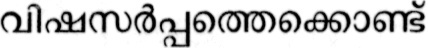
വിഷസര്‍പ്പത്തെക്കൊണ്ട്
